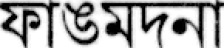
ফাঙমদনা
